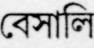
বেসালি
